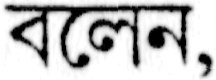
বলেন,
